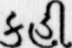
કહી
